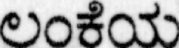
ಲಂಕೆಯ
